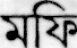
মফি
